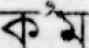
ক'ম
